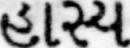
હાસ્ય
